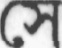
সে
